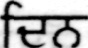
ਦਿਨ
